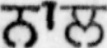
ਨਾਲ
